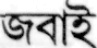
জবাই
